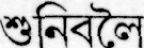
শুনিবলৈ
